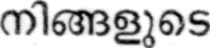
നിങ്ങളുടെ
